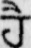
ਹੈ
